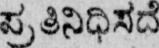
ಪ್ರತಿನಿಧಿಸದೆ
